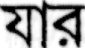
যার
